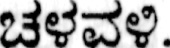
ಚಳವಳಿ.
